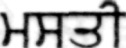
ਮਸਤੀ
